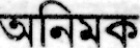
অনিমক
